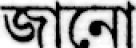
জানো
